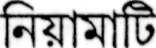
নিয়ামাটি
